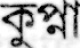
কুপ্না
